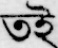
তই
